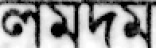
লমদম
